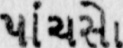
પાંચસો
